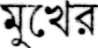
মুখের
